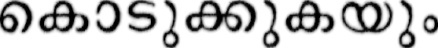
കൊടുക്കുകയും
